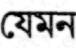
যেমন
